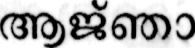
ആജ്ഞാ
